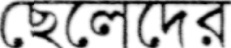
ছেলেদের
